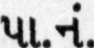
પા.નં.
